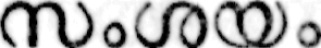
സംശയം
